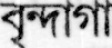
বৃন্দাগা
